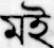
মই
